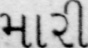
મારી
